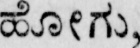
ಹೋಗು,
